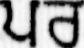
ਪਰ
